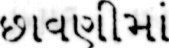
છાવણીમાં
